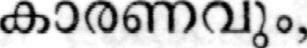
കാരണവും,
